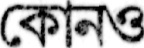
কোনও
